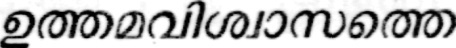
ഉത്തമവിശ്വാസത്തെ
